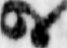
જ
